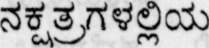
ನಕ್ಷತ್ರಗಳಲ್ಲಿಯ
